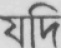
যদি
